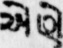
એણે
